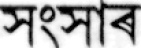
সংসাৰ
